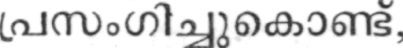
പ്രസംഗിച്ചുകൊണ്ട്,
